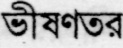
ভীষণতর
